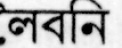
লৈবনি
